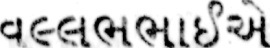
વલ્લભભાઈએ
